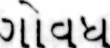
ગોવધ
